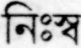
নিঃস্ব
